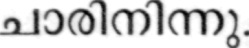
ചാരിനിന്നു.
